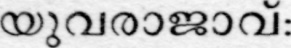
യുവരാജാവ്:
